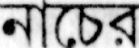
নাচের
